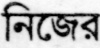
নিজের
